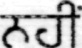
ਨਹੀਂ
